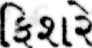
ફિશરે
